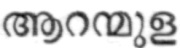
ആറന്മുള
